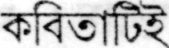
কবিতাটিই
